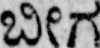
ಬೀಗ
